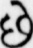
છે
